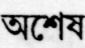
অশেষ
